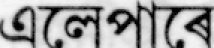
এলেপাৰে
